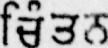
ਚਿੰਤਨ
